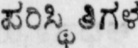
ಪರಿಸ್ಥಿತಿಗಳ
